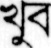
খুব
